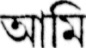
আমি
